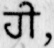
ਹੀ,
